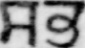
ਸਭ
